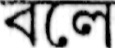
বলে
